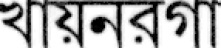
খায়নরগা
